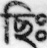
ছিঃ
